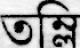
তম্লি
